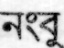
নংবু
